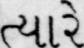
ત્યારે
